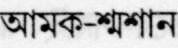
আমক-শ্মশান
